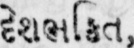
દેશભક્તિ,
